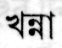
খন্না
